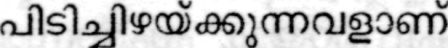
പിടിച്ചിഴയ്ക്കുന്നവളാണ്
